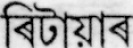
ৰিটায়াৰ
